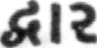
દ્વાર
